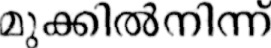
മുക്കില്‍നിന്ന്
